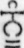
ਨੂੰ
